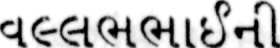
વલ્લભભાઈની
